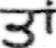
ਤਾਂ
